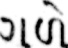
ગળે
